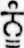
ਨੂੰ
